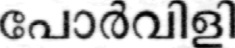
പോര്‍വിളി
